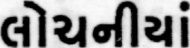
લોચનીયાં
